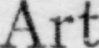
Art
